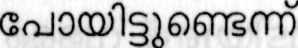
പോയിട്ടുണ്ടെന്ന്
